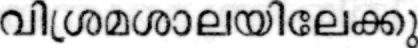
വിശ്രമശാലയിലേക്കു
